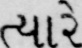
ત્યારે
